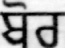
ਬੋਰ
